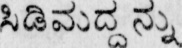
ಸಿಡಿಮದ್ದನ್ನು
